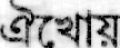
ঐখোয়
